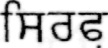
ਸਿਰਫ਼
